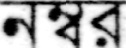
নম্বর
